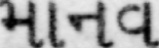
માનવ
